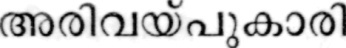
അരിവയ്പുകാരി
